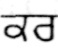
ਕਰ
